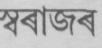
স্বৰাজৰ
